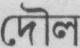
দৌল
